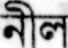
নীল
